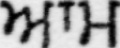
ਆਮ
